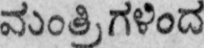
ಮಂತ್ರಿಗಳಿಂದ
